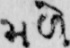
મળે
